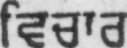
ਵਿਚਾਰ
